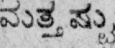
ಮತ್ತಷ್ಟು
